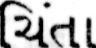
ચિંતા
